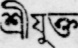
শ্রীযুক্ত
